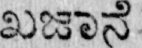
ಖಜಾನೆ
